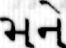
મને
